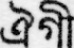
ঐগী
